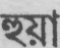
হুয়া
